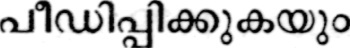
പീഡിപ്പിക്കുകയും
